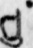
તું
